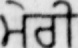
ਮੇਰੀ
